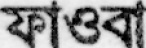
ফাওবা
